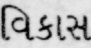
વિકાસ
